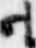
ન
